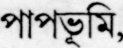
পাপভূমি,
